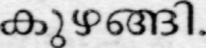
കുഴങ്ങി.
